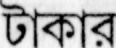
টাকার
